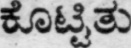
ಕೊಟ್ಟಿತು
